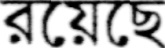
রয়েছে
